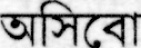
অসিবো
